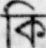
কি
